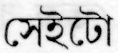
সেইটো
